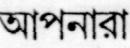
আপনারা
